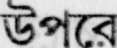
উপরে
